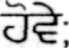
ਹੋਵੇ;
